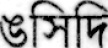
ঙসিদি
